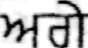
ਅਗੇ
